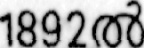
1892ല്‍
